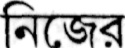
নিজের
